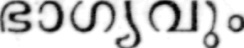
ഭാഗ്യവും
